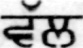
ਵੱਲ
